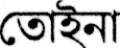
তোইনা
